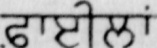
ਫ਼ਾਈਲਾਂ
